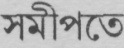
সমীপতে
